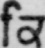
ਕਿ
